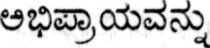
ಅಭಿಪ್ರಾಯವನ್ನು
